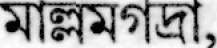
মাল্লমগদ্রা,
